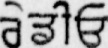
ਰੇਡੀਓ
